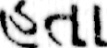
હતા
